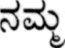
ನಮ್ಮ
